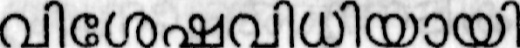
വിശേഷവിധിയായി
